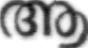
ആ
